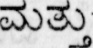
ಮತ್ತು
